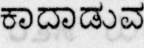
ಕಾದಾಡುವ
